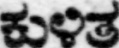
ಕುಳಿತ
